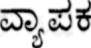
ವ್ಯಾಪಕ
